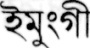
ইমুংগী
